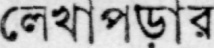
লেখাপড়ার
